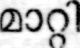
മാറ്റി
